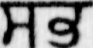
ਸਭ
